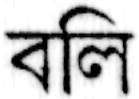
বলি
